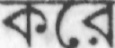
করে
